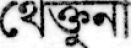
থেক্তুনা
